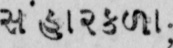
સંહારકળા;
